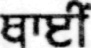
ਥਾਈਂ
